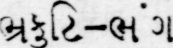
ભ્રકુટિ-ભંગ
